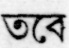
তবে
